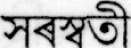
সৰস্বতী
